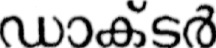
ഡാക്ടര്‍
